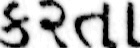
કરતા
